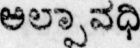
ಅಲ್ಪಾವಧಿ
